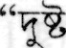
"দুষ্ট
